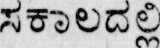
ಸಕಾಲದಲ್ಲಿ
